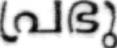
പ്രഭു
